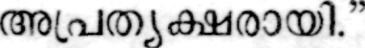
അപ്രത്യക്ഷരായി.”
